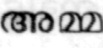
അമ്മ
